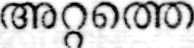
അറ്റത്തെ
